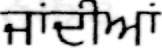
ਜਾਂਦੀਆਂ
